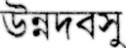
উন্নদবসু
